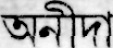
অনীদা
